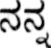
ನನ್ನ
